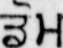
ਡੋਮ
